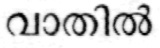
വാതില്‍
